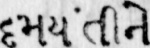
દમયંતીને
